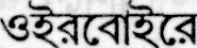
ওইরবোইরে
